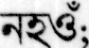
নহওঁ;
